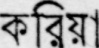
করিয়া
